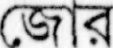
জোর
